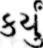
કર્યું
